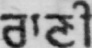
ਰਾਣੀ
